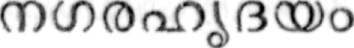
നഗരഹൃദയം
